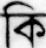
কি
